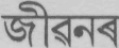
জীৱনৰ
